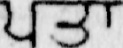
ਪਤਾ
